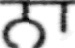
ਨਾ
